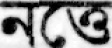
নত্তে
